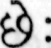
છેઃ
